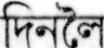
দিনলৈ
